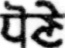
ਧੋਣੇ
